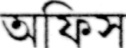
অফিস
